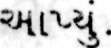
આપ્યું.
